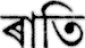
ৰাতি
